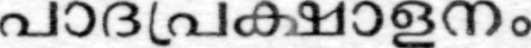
പാദപ്രക്ഷാളനം
